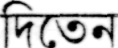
দিতেন
